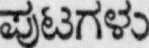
ಪುಟಗಳು
